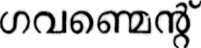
ഗവണ്മെന്റ്
